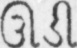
ઊડી
